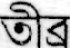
তীব্র
